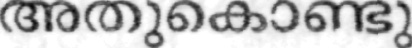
അതുകൊണ്ടു
